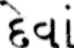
દેવાં
